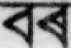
বৰ
